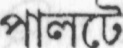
পালটে
